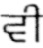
ਵੀ
